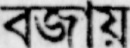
বজায়
